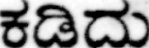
ಕಡಿದು
